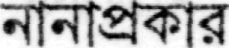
নানাপ্রকার
